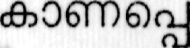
കാണപ്പെ
